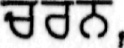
ਚਰਨ,
